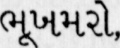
ભૂખમરો,
